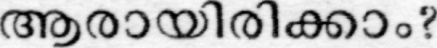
ആരായിരിക്കാം?
